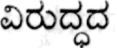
ವಿರುದ್ಧದ
